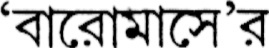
'বারোমাসে'র
